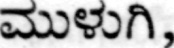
ಮುಳುಗಿ,
